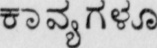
ಕಾವ್ಯಗಳೂ
